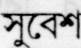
সুবেশ
